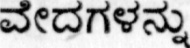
ವೇದಗಳನ್ನು
